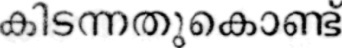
കിടന്നതുകൊണ്ട്
